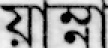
য়াম্না
